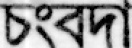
চংবদা
